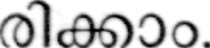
രിക്കാം.
